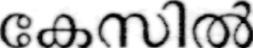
കേസില്‍
